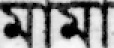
মামা
